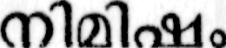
നിമിഷം
